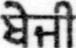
ਬੇਜੀ
